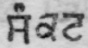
ਸੰਕਟ
